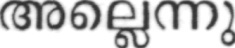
അല്ലെന്നു
